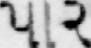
પાર
